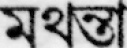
মথন্তা
